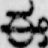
ಈ
